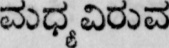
ಮಧ್ಯವಿರುವ
